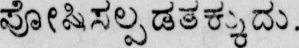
ಪೋಷಿಸಲ್ಪಡತಕ್ಕುದು.
